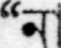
‘‘না
